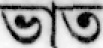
ভাত
